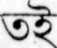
তই
